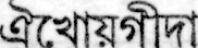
ঐখোয়গীদা
